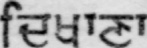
ਦਿਖਾਣਾ
